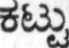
ಕಟ್ಟು
